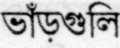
ভাঁড়গুলি
